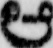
ಆ
